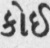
કોઈ
